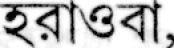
হরাওবা,
